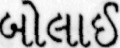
બોલાઈ
